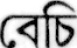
বেচি
